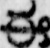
ಈ
